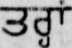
ਤਰ੍ਹਾਂ
